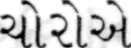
ચોરોએ
